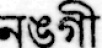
নঙগী
